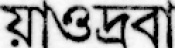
য়াওদ্রবা
